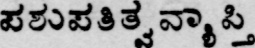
ಪಶುಪತಿತ್ವವ್ಯಾಪ್ತಿ
